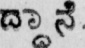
ದ್ದಾನೆ.
